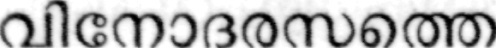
വിനോദരസത്തെ
